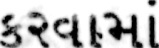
કરવામાં
